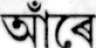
আঁৰে
